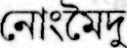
নোংমৈদু
